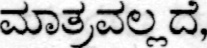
ಮಾತ್ರವಲ್ಲದೆ,
